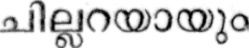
ചില്ലറയായും
